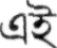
এই
